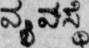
ವ್ಯವಸ್ಥೆ
